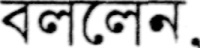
বললেন,
